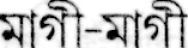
মাগী-মাগী
